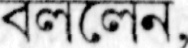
বললেন,
